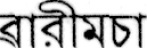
ৱারীমচা
